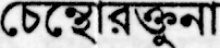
চেন্থোরক্তুনা
